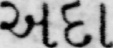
અદા
